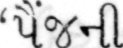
'પૈંજની
